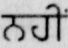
ਨਹੀਂ
